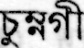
চুম্নগী
